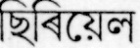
ছিৰিয়েল
